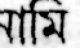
নামি
